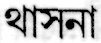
থাসনা
